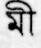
মী
